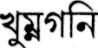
খুম্নগনি
